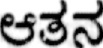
ಆತನ
